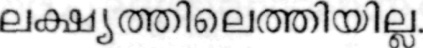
ലക്ഷ്യത്തിലെത്തിയില്ല.
